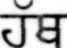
ਹੱਥ
